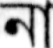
না
